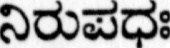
ನಿರುಪಧಃ
